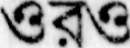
ওরও
